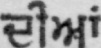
ਦੀਆਂ
